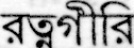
রত্নগীরি
